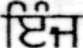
ਇੰਜ
